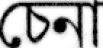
চেনা
